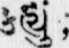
કહ્યું,
